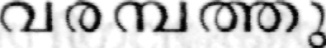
വരമ്പത്തു
